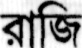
রাজি
